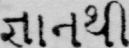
જ્ઞાનથી
